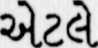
એટલે
